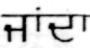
ਜਾਂਦਾ
